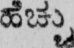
ಹೆಚ್ಚು
